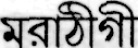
মরাঠীগী
